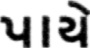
પાયે
